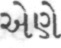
એણે
